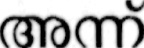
അന്ന്
